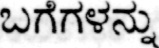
ಬಗೆಗಳನ್ನು
